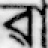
ৱা
